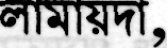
লামায়দা,
